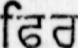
ਫਿਰ
